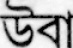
উবা
